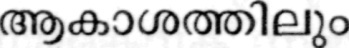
ആകാശത്തിലും
